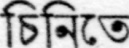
চিনিতে
